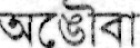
অঙৌবা
